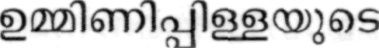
ഉമ്മിണിപ്പിള്ളയുടെ
